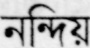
নন্দিয়
